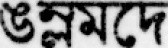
ঙম্লমদে
